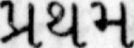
પ્રથમ
